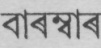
বাৰম্বাৰ
